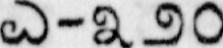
ಎ-೩೨೦
